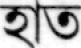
হাত
